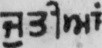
ਜੁਤੀਆਂ
